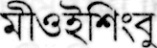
মীওইশিংবু
